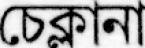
চেক্লানা
